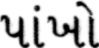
પાંખો
